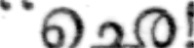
“ഛെ!
